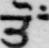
ਤੋਂ
